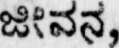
ಜೀವನ,
